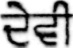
ਦੇਵੀ
